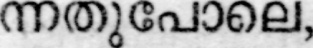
ന്നതുപോലെ,
